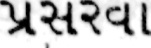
પ્રસરવા
